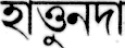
হাত্তুনদা
